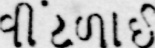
વીંટળાઈ
